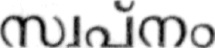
സ്വപ്നം
